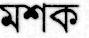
মশক
